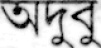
অদুবু
